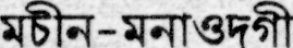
মচীন-মনাওদগী
